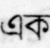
এক
